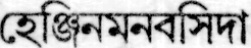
হেঞ্জিনমনবসিদা
